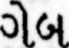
ગેબ
